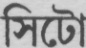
সিটো
